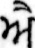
ਐ
